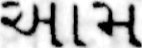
આમ
